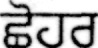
ਛੋਹਰ
